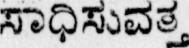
ಸಾಧಿಸುವತ್ತ
